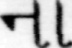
ના
